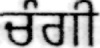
ਚੰਗੀ
